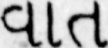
વાત
